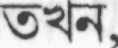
তখন,
